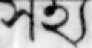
সহ্য
